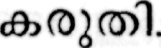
കരുതി.
